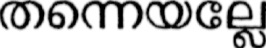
തന്നെയല്ലേ
